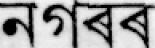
নগৰৰ
